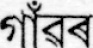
গাঁৱৰ
